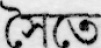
সৈতে
